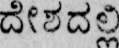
ದೇಶದಲ್ಲಿ
